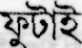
ফুটাই
